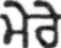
ਮੇਰੇ
